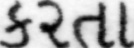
કરતા
